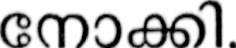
നോക്കി.
